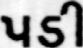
પડી
